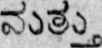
ಮತ್ತು
